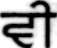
ਵੀ
